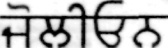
ਜੋਲੀਓਨ
